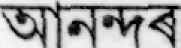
আনন্দৰ
